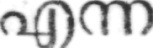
എന്ന
